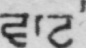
ਵਾਟ'
